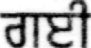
ਗਈ
